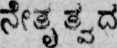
ನೇತೃತ್ವದ
